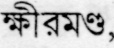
ক্ষীরমণ্ড,
